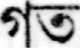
গত
